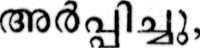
അര്‍പ്പിച്ചു,
